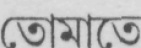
তোমাতে
